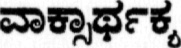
ವಾಕ್ಸಾರ್ಥಕ್ಯ
